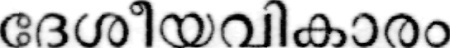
ദേശീയവികാരം
